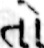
તો
